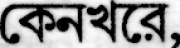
কেনখরে,
